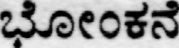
ಭೋಂಕನೆ
